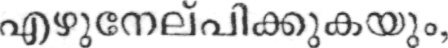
എഴുനേല്പിക്കുകയും,
